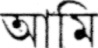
আমি
